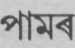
পামৰ
